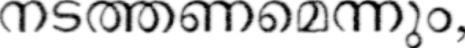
നടത്തണമെന്നും,
